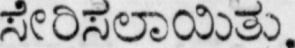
ಸೇರಿಸಲಾಯಿತು.
